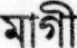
মাগী
